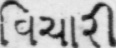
વિચારી
